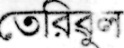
তেরিৱুল
